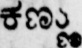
ಕಣ್ಣು
